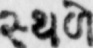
સ્થળે
